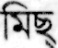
মিছ্
